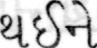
થઈને
